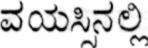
ವಯಸ್ಸಿನಲ್ಲಿ
